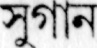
সুগান
